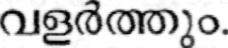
വളര്‍ത്തും.
